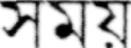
সময়
